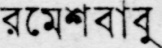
রমেশবাবু
